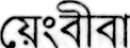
য়েংবীবা
